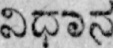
ವಿಧಾನ
